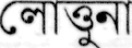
লোত্তুনা
